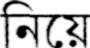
নিয়ে
